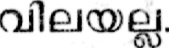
വിലയല്ല.
